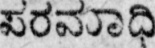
ಪರಮಾಧಿ
